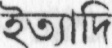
ইত্যাদি
